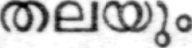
തലയും
